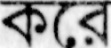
করে
